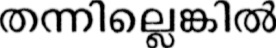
തന്നില്ലെങ്കില്‍
